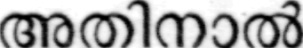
അതിനാല്‍
